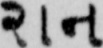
રાન
